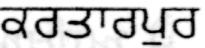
ਕਰਤਾਰਪੁਰ
